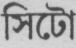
সিটো
